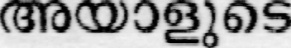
അയാളുടെ
